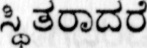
ಸ್ಥಿತರಾದರೆ
